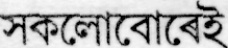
সকলোবোৰেই
